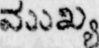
ಮುಖ್ಯ
